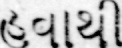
હવાથી
